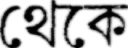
থেকে
